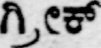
ಗ್ರೀಕ್
